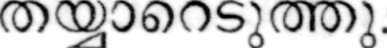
തയ്യാറെടുത്തു.
